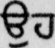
ਉਹ
